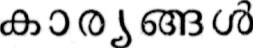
കാര്യങ്ങള്‍
